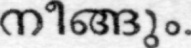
നീങ്ങും.
